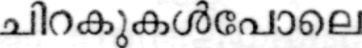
ചിറകുകള്‍പോലെ
